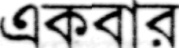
একবার
